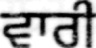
ਵਾਰੀ
